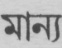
মান্য
